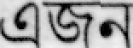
এজন
